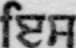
ਇਸ
